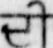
ਦੀ
